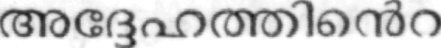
അദ്ദേഹത്തിന്റെ
